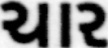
ચાર
